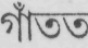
গাঁতত
